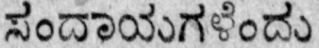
ಸಂದಾಯಗಳೆಂದು
